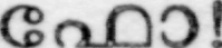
ഫോ!
